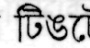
টিঙ
